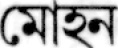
মোহন
